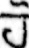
ਹੋ
